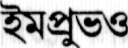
ইমপ্রুভও
